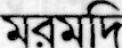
মরমদি
